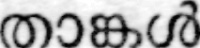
താങ്കള്‍
